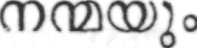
നന്മയും
